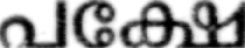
പക്ഷേ
